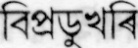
বিপ্রডুখৰি
